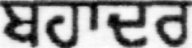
ਬਹਾਦਰ
